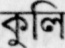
কুলি
